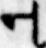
ન
